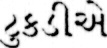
ટુકડીએ
